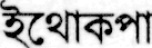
ইথোকপা
